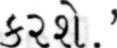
કરશે.'
